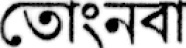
তোংনবা
